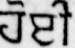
ਹੋਈ
